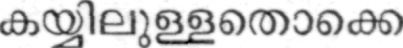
കയ്യിലുള്ളതൊക്കെ
